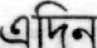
এদিন
